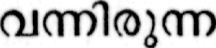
വന്നിരുന്ന
